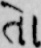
તો
